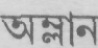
অম্লান
